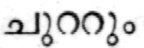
ചുററും
